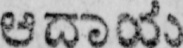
ಆದಾಯ
